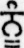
ਨੂੰ
